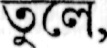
তুলে,
